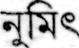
নুমিৎ
